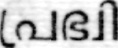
പ്രഭ്വി
